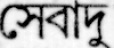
সেবাদু
